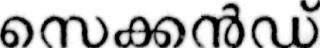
സെക്കന്‍ഡ്
